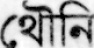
থৌনি
